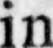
in
